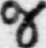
જ
